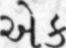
એક
